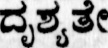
ದೃಶ್ಯತೇ
